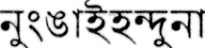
নুংঙাইহন্দুনা
